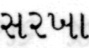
સરખા
